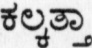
ಕಲ್ಕತ್ತಾ
